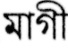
মাগী
